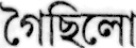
গৈছিলো
